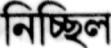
নিচ্ছিল
